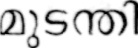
മുടന്തി
